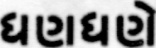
ધણધણે
